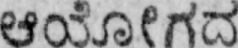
ಆಯೋಗದ
